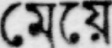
মেয়ে
